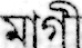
মাগী
